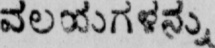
ವಲಯಗಳನ್ನು
